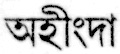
অহীংদা
